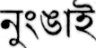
নুংঙাই
